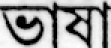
ভাষা
